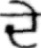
ਦੇ
